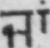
ਜਾਂ
